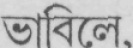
ভাবিলে,
